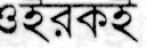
ওইরকই
